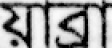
য়াব্রা
